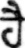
ਹੈ
